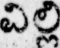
ವಿಲ್ಲಿ
